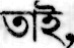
তাই,
